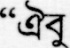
“ঐবু
